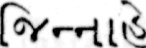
જિન્નાહે
